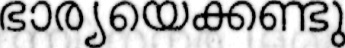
ഭാര്യയെക്കണ്ടു
